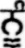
ਨੂੰ
